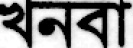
খনবা
